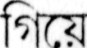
গিয়ে
